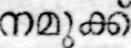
നമുക്ക്
